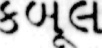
કબૂલ
